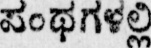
ಪಂಥಗಳಲ್ಲಿ
